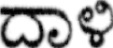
ದಾಳಿ
